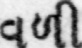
વળી
